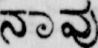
ನಾವು
